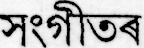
সংগীতৰ
